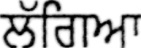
ਲੱਗਿਆ
